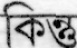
কিন্তু
